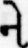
ને
